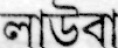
লাউবা
